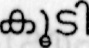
കൂടി
